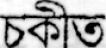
চকীত
